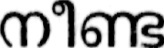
നീണ്ട
